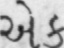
એક
